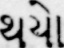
થયો
